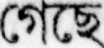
গেছে
